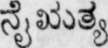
ನೈಋತ್ಯ
